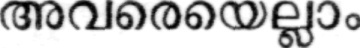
അവരെയെല്ലാം
